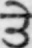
ਤੇ
